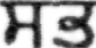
ਸਭ
